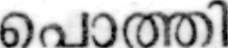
പൊത്തി
